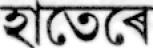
হাতেৰে
